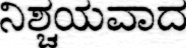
ನಿಶ್ಚಯವಾದ
